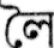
লৈ
